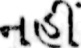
નહીં
